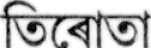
তিৰোতা
